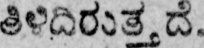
ತಿಳಿದಿರುತ್ತದೆ.
